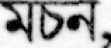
মচন,
